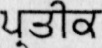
ਪ੍ਰਤੀਕ
